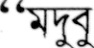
“মদুবু
